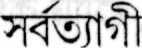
সর্বত্যাগী
